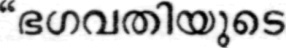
"ഭഗവതിയുടെ
